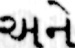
અને
